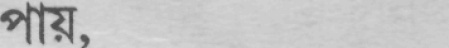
পায়,
